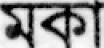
মকা
